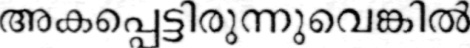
അകപ്പെട്ടിരുന്നുവെങ്കില്‍
